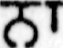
ਨਾ
